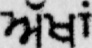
ਅੱਖਾਂ
